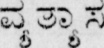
ವ್ಯತ್ಯಾಸ
